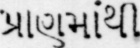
પ્રાણમાંથી
